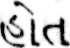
હોત
